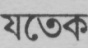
যতেক
